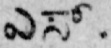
ಎಸ್.
